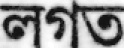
লগত
